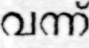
വന്ന്
